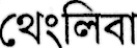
থেংলিবা
